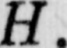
H.
